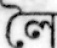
লৈ
